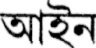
আইন
